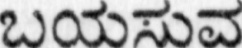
ಬಯಸುವ
